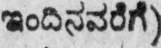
ಇಂದಿನವರೆಗೆ)
